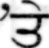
'ਤੇ
